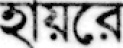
হায়রে
